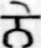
ਨੇ
